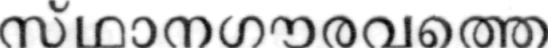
സ്ഥാനഗൌരവത്തെ
